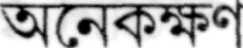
অনেকক্ষণ
